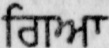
ਗਿਆ
